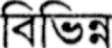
বিভিন্ন
